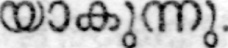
യാകുന്നു.
